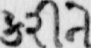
કરીને
